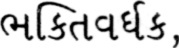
ભક્તિવર્ધક,
